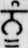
ਨੂੰ
